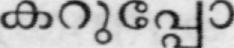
കറുപ്പോ
